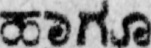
ಹಾಗೂ
